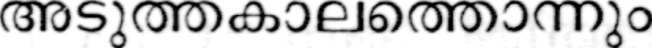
അടുത്തകാലത്തൊന്നും
